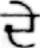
ਦੇ
